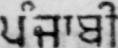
ਪੰਜਾਬੀ
